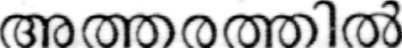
അത്തരത്തില്‍
